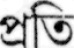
প্রতি
